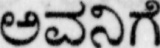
ಅವನಿಗೆ
